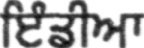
ਇੰਡੀਆ
